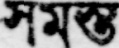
সমস্ত
